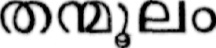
തന്മൂലം
